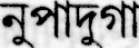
নুপাদুগা
